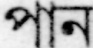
পান
